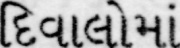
દિવાલોમાં
